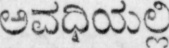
ಅವಧಿಯಲ್ಲಿ
